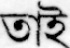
তাই
